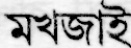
মখজাই
